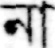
না
